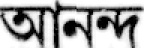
আনন্দ
